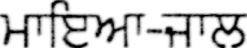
ਮਾਇਆ-ਜਾਲ
